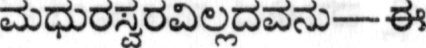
ಮಧುರಸ್ವರವಿಲ್ಲದವನು-ಈ
